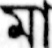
মা
